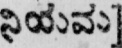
ನಿಯಮ]
